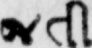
જતી
